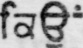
ਕਿਉਂ
